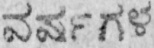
ವರ್ಷಗಳ
